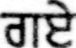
ਗਏ
